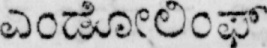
ಎಂಡೋಲಿಂಫ್
